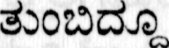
ತುಂಬಿದ್ದೂ
